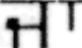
ਜਾ
